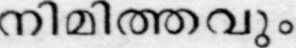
നിമിത്തവും
